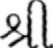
શ્રી
